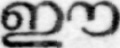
ഈ
